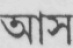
আস
